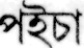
পইচা
